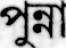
পুন্না
